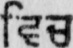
ਵਿਚ
